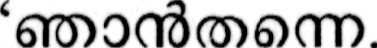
‘ഞാന്‍തന്നെ.
